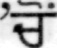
'ਚੋਂ
